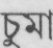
চুমা
